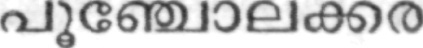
പൂഞ്ചോലക്കര
